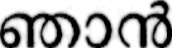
ഞാന്‍
